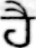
ਹੈ
